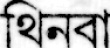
থিনবা
